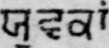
ਯੁਵਕਾਂ
